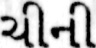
ચીની
